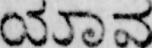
ಯಾವ
